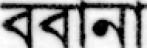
ববানা
